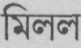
মিলল
